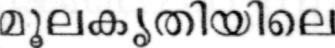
മൂലകൃതിയിലെ
